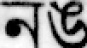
নঙ
